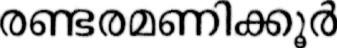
രണ്ടരമണിക്കൂര്‍
